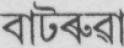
বাটৰুৱা
